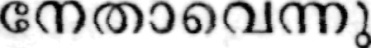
നേതാവെന്നു
